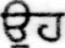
ਉਹ
